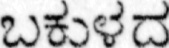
ಬಕುಳದ
